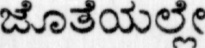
ಜೊತೆಯಲ್ಲೇ
